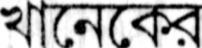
খানেকের
